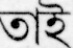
তাই
